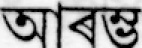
আৰম্ভ
